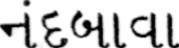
નંદબાવા
